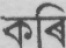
কৰি
